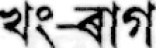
খং-ৰাগ
